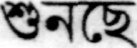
শুনছে
